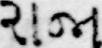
રાજા
